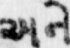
અને
